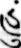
હું
